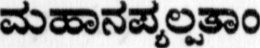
ಮಹಾನಪ್ಯಲ್ಪತಾಂ
